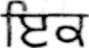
ਇਕ
